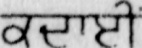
ਕਦਾਈਂ
